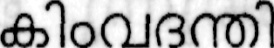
കിംവദന്തി
